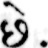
છે.
